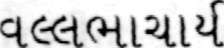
વલ્લભાચાર્ય
